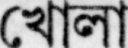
খোলা
